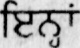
ਇਨ੍ਹਾਂ
